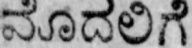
ಮೊದಲಿಗೆ
